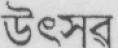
উৎসৱ
